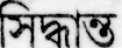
সিদ্ধান্ত
